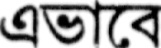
এভাবে
